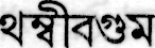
থম্বীবগুম
